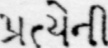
પ્રત્યેની
